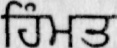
ਹਿੰਮਤ
